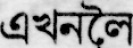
এখনলৈ
